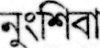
নুংশিবা
